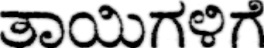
ತಾಯಿಗಳಿಗೆ
